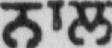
ਨਾਲ
